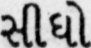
સીધો
